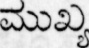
ಮುಖ್ಯ
